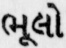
કહેવાય.
